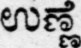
ಉಣ್ಣೆ
